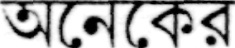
অনেকের
